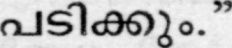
പടിക്കും."
